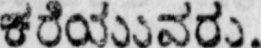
ಕರೆಯುವರು.
